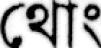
থোং
